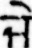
ਜੇ
